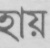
হায়
